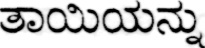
ತಾಯಿಯನ್ನು
